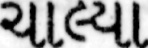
ચાલ્યા
